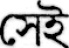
সেই
